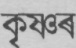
কৃষ্ণৰ
